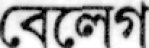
বেলেগ
